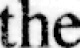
the
